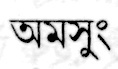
অমসুং
